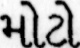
મોટો
